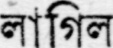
লাগিল
